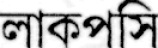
লাকপসি
